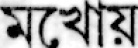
মখোয়
